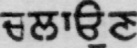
ਚਲਾਉਣ
